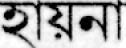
হায়না
